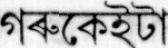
গৰুকেইটা
